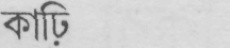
কাঢ়ি
